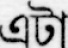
এটা
